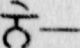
ਨੇ-
